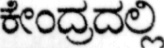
ಕೇಂದ್ರದಲ್ಲಿ
